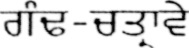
ਗੰਢ-ਚਤ੍ਰਾਵੇ
